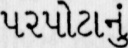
પરપોટાનું
